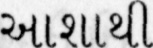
આશાથી
